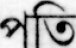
পতি
